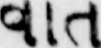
વાત
